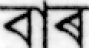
বাৰ
